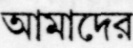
আমাদের
